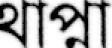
থাপ্না
